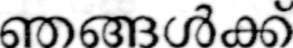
ഞങ്ങള്‍ക്ക്
